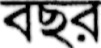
বছর
